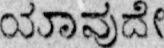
ಯಾವುದೇ
